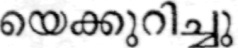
യെക്കുറിച്ചു
